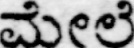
ಮೇಲೆ
